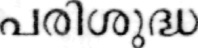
പരിശുദ്ധ
